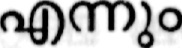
എന്നും
